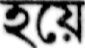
হয়ে
